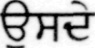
ਉਸਦੇ
